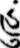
હું
